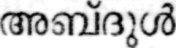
അബ്ദുള്‍
